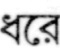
ধরে
